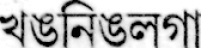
খঙনিঙলগা
